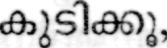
കുടിക്കൂ,
